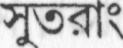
সুতরাং
